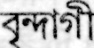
বৃন্দাগী
